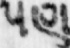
પણ
